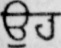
ਉਹ
